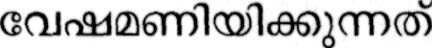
വേഷമണിയിക്കുന്നത്
